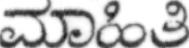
ಮಾಹಿತಿ
